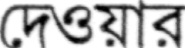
দেওয়ার
